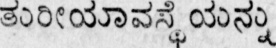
ತುರೀಯಾವಸ್ಥೆಯನ್ನು
